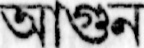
আগুন
